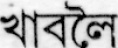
খাবলৈ
